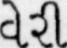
વેરી
